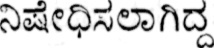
ನಿಷೇಧಿಸಲಾಗಿದ್ದ
